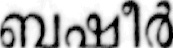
ബഷീര്‍
